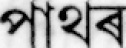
পাথৰ
